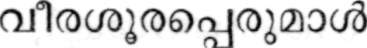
വീരശൂരപ്പെരുമാള്‍
